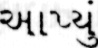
આપ્યું
